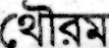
থৌরম
